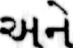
અને
